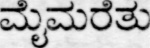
ಮೈಮರೆತು
